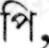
পি,
